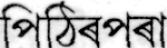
পিঠিৰপৰা
